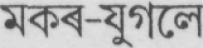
মকৰ-যুগলে
